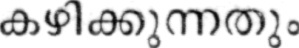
കഴിക്കുന്നതും
